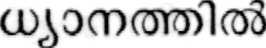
ധ്യാനത്തില്‍
